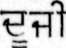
ਦੂਜੀ
